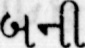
બની
